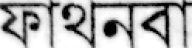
ফাথনবা
